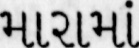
મારામાં
